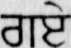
ਗਏ
